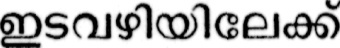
ഇടവഴിയിലേക്ക്
